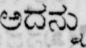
ಅದನ್ನು
